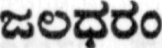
ಜಲಧರಂ
